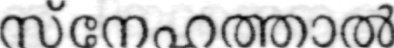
സ്നേഹത്താല്‍
